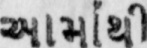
આમાંથી
